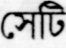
সেটি
